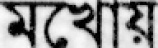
মখোয়
